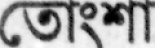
তোংশা
